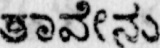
ತಾವೇನು
